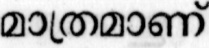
മാത്രമാണ്
